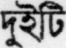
দুইটি
